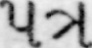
પત્ર
